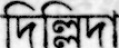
দিল্লিদা
